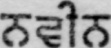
ਨਵੀਨ
